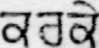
ਕਰਕੇ
